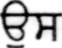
ਉਸ
